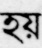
হয়
